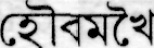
হৌবমখৈ
